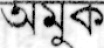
অমুক
